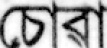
চোৱা
